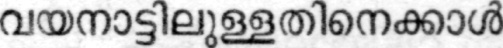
വയനാട്ടിലുള്ളതിനെക്കാള്‍
